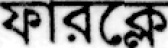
ফারক্লে
